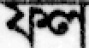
ফল
